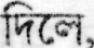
দিলে,
